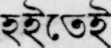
হইতেই
